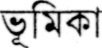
ভূমিকা
